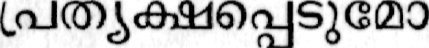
പ്രത്യക്ഷപ്പെടുമോ
